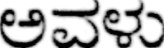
ಅವಳು
